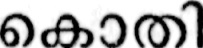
കൊതി
